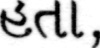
હતા,
